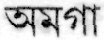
অমগা
